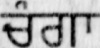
ਚੰਗਾ
